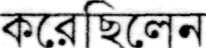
করেছিলেন
